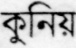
কুনিয়
